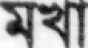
মখা
